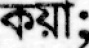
কয়া;
